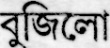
বুজিলো
